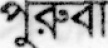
পুরুবা
